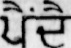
ਪੈਂਦੈ
